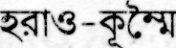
হরাও-কুম্মৈ
